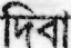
দিবা
